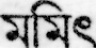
মমিৎ
